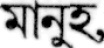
মানুহ,
